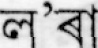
ল'ৰা
